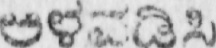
ಅಳವಡಿಸಿ
